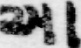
આ
